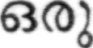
ഒരു
